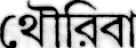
থৌরিবা
